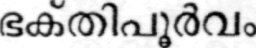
ഭക്തിപൂര്‍വം
